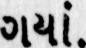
ગયાં.
